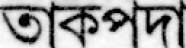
তাকপদা
